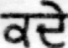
ਕਦੇ
